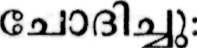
ചോദിച്ചു:
